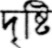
দৃষ্টি
